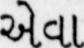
એવા
